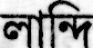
লান্দি
